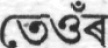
তেওঁৰ
